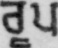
ਰੂਪ
